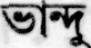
ভান্দু
